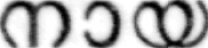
നായ
